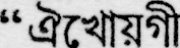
“ঐখোয়গী
